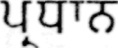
ਪ੍ਰਧਾਨ
